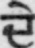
ਦੇ
